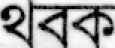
থবক
